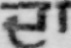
ਦਾ
